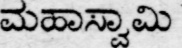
ಮಹಾಸ್ವಾಮಿ
